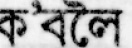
ক'বলৈ
